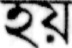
হয়
